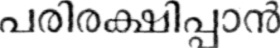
പരിരക്ഷിപ്പാന്‍
